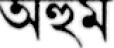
অহুম
